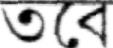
তবে
